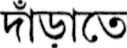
দাঁড়াতে
